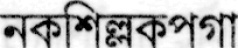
নকশিল্লকপগা
